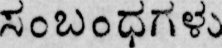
ಸಂಬಂಧಗಳು
